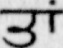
ਤਾਂ
